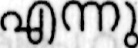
എന്നു
